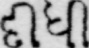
દીધી
